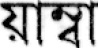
য়াম্বা
